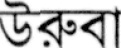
ঊরুবা
